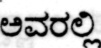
ಅವರಲ್ಲಿ
